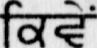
ਕਿਵੇਂ
